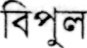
বিপুল
